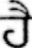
ਹੈ
